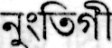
নুংতিগী
